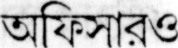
অফিসারও
